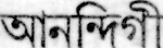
আনন্দিগী
